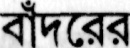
বাঁদরের
